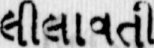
લીલાવતી
